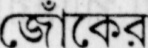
জোঁকের
